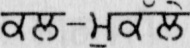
ਕਲ-ਮੁਕੱਲੇ
